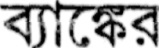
ব্যাঙ্কের
